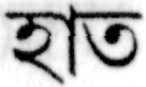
হাত
